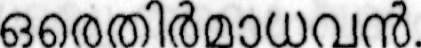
ഒരെതിര്‍മാധവന്‍.
